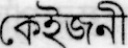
কেইজনী
